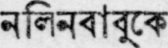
নলিনবাবুকে
